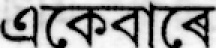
একেবাৰে
